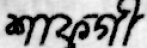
শাফূগী
